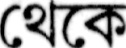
থেকে
